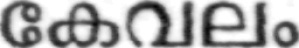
കേവലം
